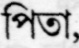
পিতা,
